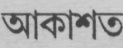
আকাশত
